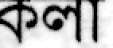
কলা
